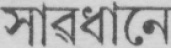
সাৱধানে
